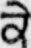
ਕੇ
